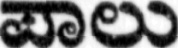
ಪಾಲು
